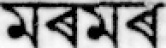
মৰমৰ
